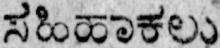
ಸಹಿಹಾಕಲು
